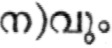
ന)വും
